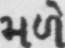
મળે
